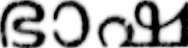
ഭാഷ
